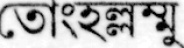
তোংহল্লম্মু
